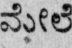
ಮೇಲೆ
